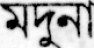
মদুনা
